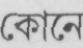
কোনে
